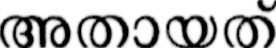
അതായത്
